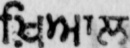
ਖ਼ਿਆਲ
